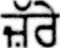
ਜ਼ੱਰੇ
